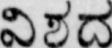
ವಿಶದ
